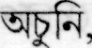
অচুনি,
